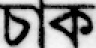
চাক
